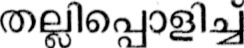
തല്ലിപ്പൊളിച്ച്
